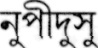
নুপীদুসু
